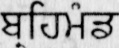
ਬ੍ਰਹਿਮੰਡ
